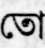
তো
